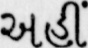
અહીં
